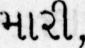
મારી,
